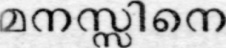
മനസ്സിനെ
